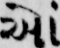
ઓં
